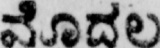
ಮೊದಲ
